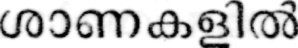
ശാണകളില്‍
